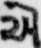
એ
